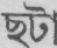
ছটা
